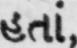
હતાં,
